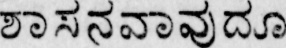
ಶಾಸನವಾವುದೂ
